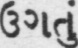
ઉગતું
